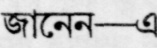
জানেন–এ
